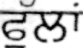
ਫੁੱਲਾਂ
